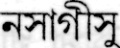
নসাগীসু
